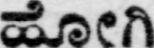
ಹೋಗಿ
